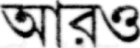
আরও
